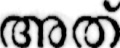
അത്
